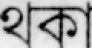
থকা
